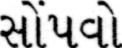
સોંપવો
